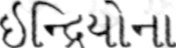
ઈન્દ્રિયોના
